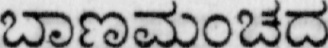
ಬಾಣಮಂಚದ
